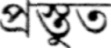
প্রস্তুত
